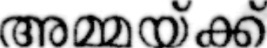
അമ്മയ്ക്ക്
